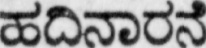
ಹದಿನಾರನೆ
